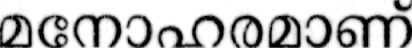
മനോഹരമാണ്
